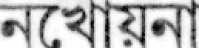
নখোয়না
